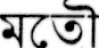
মতৌ
